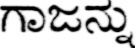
ಗಾಜನ್ನು
